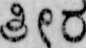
ತೀರ
